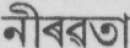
নীৰৱতা
